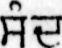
ਸੰਦ
